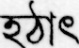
হঠাৎ
